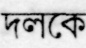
দলকে
